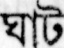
ঘাট
